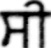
ਸੀ
